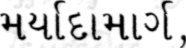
મર્યાદામાર્ગ,
